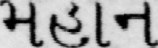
મહાન
